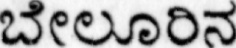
ಬೇಲೂರಿನ
